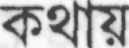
কথায়
